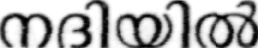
നദിയില്‍
